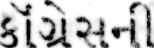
કૉંગ્રેસની
